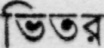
ভিতর
